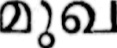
മുഖ
